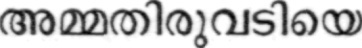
അമ്മതിരുവടിയെ
